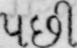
પછી
